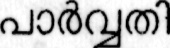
പാര്‍വ്വതി
